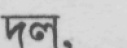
দল,
